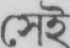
সেই
